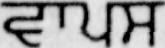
ਵਾਪਸ
